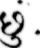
છું.
